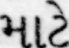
માટે
